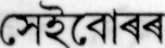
সেইবোৰৰ
